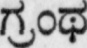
ಗ್ರಂಥ
